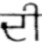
ਦੀ
